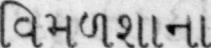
વિમળશાના
